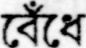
বেঁধে
